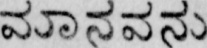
ಮಾನವನು
